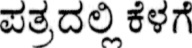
ಪತ್ರದಲ್ಲಿಕೆಳಗೆ
